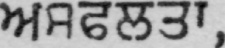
ਅਸਫਲਤਾ,
